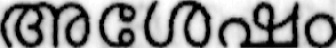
അശേഷം
